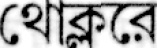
থোক্লরে
